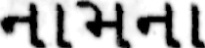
નામના
